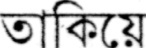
তাকিয়ে
